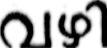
വഴി
